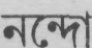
নন্দো
